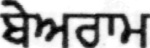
ਬੇਅਰਾਮ
